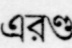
এরণ্ড
